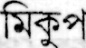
মিকুপ
